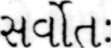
સર્વોતઃ
